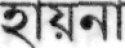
হায়না
